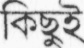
কিছুই
